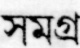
সমগ্র
